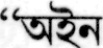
"অইন
